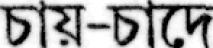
চায়-চাদে
